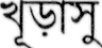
খূড়াসু
